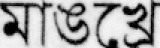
মাঙখ্রে
